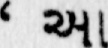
'આ
